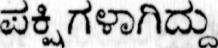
ಪಕ್ಷಿಗಳಾಗಿದ್ದು
